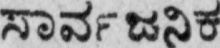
ಸಾರ್ವಜನಿಕ
